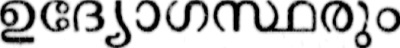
ഉദ്യോഗസ്ഥരും
